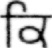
ਕਿ
